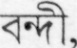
বন্দী,
